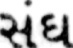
સંઘ
